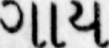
ગાય
